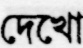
দেখো
